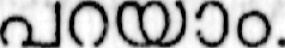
പറയാം.
